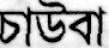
চাউবা
